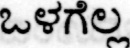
ಒಳಗೆಲ್ಲ
